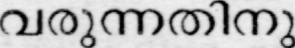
വരുന്നതിനു
